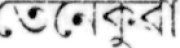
তেনেকুৱা
